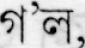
গ'ল,
